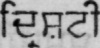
ਦ੍ਰਿਸ਼ਟੀ
